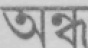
অন্ধ
